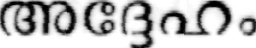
അദ്ദേഹം
